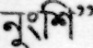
নুংশি”
